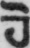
ਹੋ
